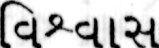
વિશ્વાસ
